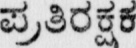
ಪ್ರತಿರಕ್ಷಕ
